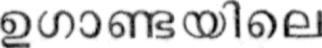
ഉഗാണ്ടയിലെ
